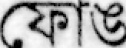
ফোঙ
